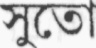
সুতো
